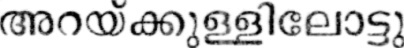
അറയ്ക്കുള്ളിലോട്ടു
